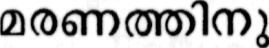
മരണത്തിനു
